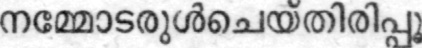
നമ്മോടരുള്‍ചെയ്തിരിപ്പൂ
